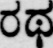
ರಥ
